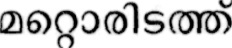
മറ്റൊരിടത്ത്
